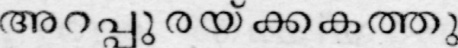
അറപ്പുരയ്ക്കകത്തു
